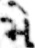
મે
